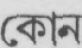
কোন
